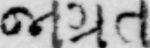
જાગ્રત
